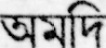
অমদি
